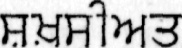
ਸ਼ਖ਼ਸੀਅਤ
